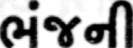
ભંજની
